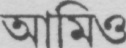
আমিও
